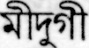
মীদুগী
